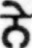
ਨੇ
